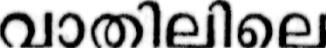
വാതിലിലെ
